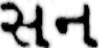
સન
